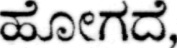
ಹೋಗದೆ,
